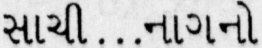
સાચી...નાગનો
